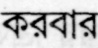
করবার
